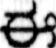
ಈ
